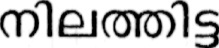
നിലത്തിട്ട
